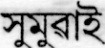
সুমুৱাই
